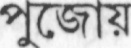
পুজোয়
